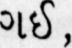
ગઈ,
